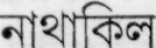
নাথাকিল
